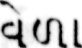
વેળા
